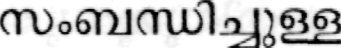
സംബന്ധിച്ചുള്ള
